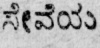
ಸೇವೆಯ
